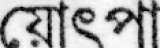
য়োৎপা
